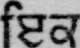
ਇਕ
